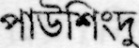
পাউশিংদু
